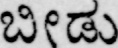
ಬೀಡು
